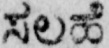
ಸಲಹೆ
